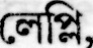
লেপ্লি,
